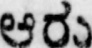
ಆರು
